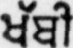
ਖੱਬੀ
